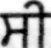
ਸੀ
